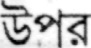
উপর
